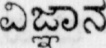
ವಿಜ್ಞಾನ
